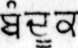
ਬੰਦੂਕ
